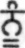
ਨੂੰ
